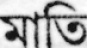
মাতি
